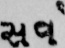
સર્વ
